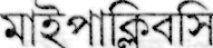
মাইপাক্লিবসি
